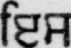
ਇਸ
